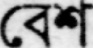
বেশ
